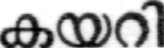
കയറി
